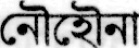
নৌহৌনা
